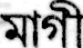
মাগী
